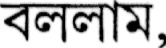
বললাম,
